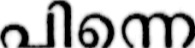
പിന്നെ
